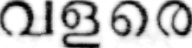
വളരെ
